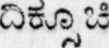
ದಿಕ್ಸೂಚಿ
